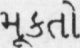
મૂકતો
